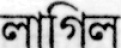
লাগিল
